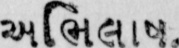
અભિલાષ
